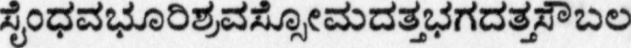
ಸೈಂಧವಭೂರಿಶ್ರವಸ್ಸೋಮದತ್ತಭಗದತ್ತಸೌಬಲ
